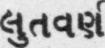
લુતવર્ણ
